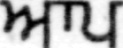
ਆਪ
